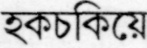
হকচকিয়ে
